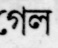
গেল
